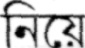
নিয়ে
